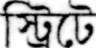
স্ট্রিটে
